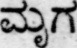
ಮೃಗ
